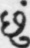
છું
